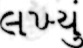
લખ્યું
